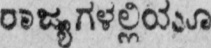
ರಾಜ್ಯಗಳಲ್ಲಿಯೂ
